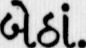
બેઠાં.
